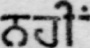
ਨਹੀਂ
